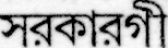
সরকারগী
